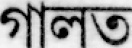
গালত
